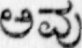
ಅವು
